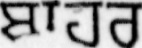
ਬਾਹਰ
